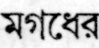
মগধের
